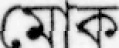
মোক
